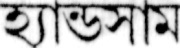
হ্যান্ডসাম
